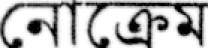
নোক্রেম
